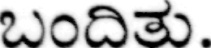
ಬಂದಿತು.
